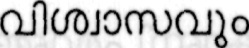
വിശ്വാസവും
